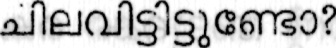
ചിലവിട്ടിട്ടുണ്ടോ?
